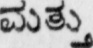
ಮತ್ತು
